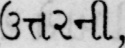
ઉત્તરની,
